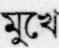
মুখে
